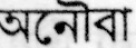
অনৌবা
